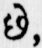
છે,
